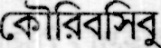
কৌরিবসিবু
